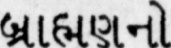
બ્રાહ્મણનો
